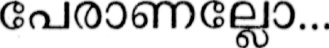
പേരാണല്ലോ...
